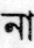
না
